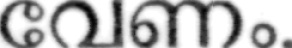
വേണം.
